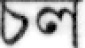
চল
